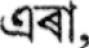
এৰা,
